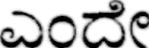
ಎಂದೇ
